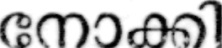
നോക്കി
